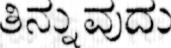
ತಿನ್ನುವುದು
